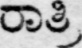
ರಾತ್ರಿ
